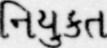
નિયુકત
